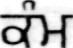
ਕੰਮ
